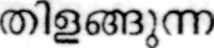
തിളങ്ങുന്ന
